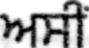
ਅਸੀਂ
